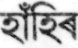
হাঁহিৰ
